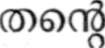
തന്റെ
